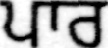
ਪਾਰ
